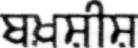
ਬਖ਼ਸ਼ੀਸ਼
